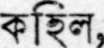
কহিল,
